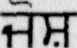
ਜੋਸ਼
